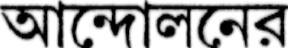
আন্দোলনের
